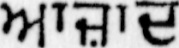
ਆਜ਼ਾਦ
